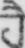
ਹੈ
